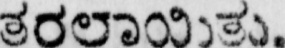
ತರಲಾಯಿತು.
